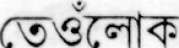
তেওঁলোক
